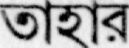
তাহার
